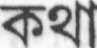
কথা
